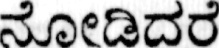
ನೋಡಿದರೆ
